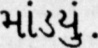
માંડયું.
